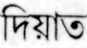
দিয়াত
